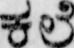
ಕಲೆ
